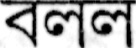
বলল
